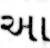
આ
